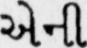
એની
